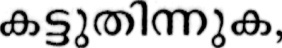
കട്ടുതിന്നുക,
